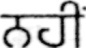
ਨਹੀਂ
